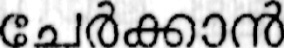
ചേര്‍ക്കാന്‍
